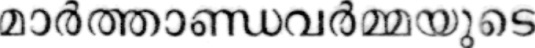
മാര്‍ത്താണ്ഡവര്‍മ്മയുടെ
